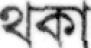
থকা
